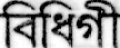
বিধিগী
